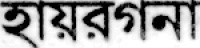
হায়রগনা
